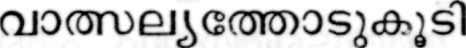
വാത്സല്യത്തോടുകൂടി
